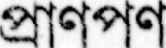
প্রাণপণ
